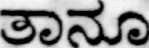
ತಾನೂ
